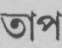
তাপ
